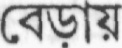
বেড়ায়
